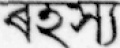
ৰহস্য
